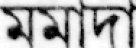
মমাদা
